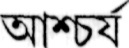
আশ্চর্য
